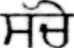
ਸੱਚੇ
